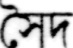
সৈদ
